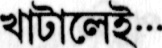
খাটালেই...
